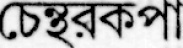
চেন্থরকপা
